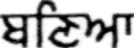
ਬਣਿਆ
